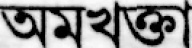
অমখক্তা
